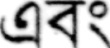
এবং
